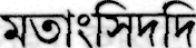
মতাংসিদদি
